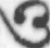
ও
